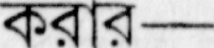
করার-
